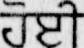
ਹੋਈ
